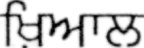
ਖ਼ਿਆਲ
